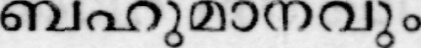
ബഹുമാനവും
